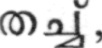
തച്ച്,
